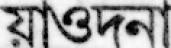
য়াওদনা
